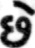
છે
